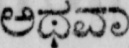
ಅಥವಾ
